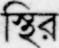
স্থির
